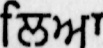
ਲਿਆ
